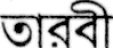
তারবী
